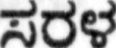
ಸರಳ
